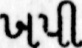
ખપી
